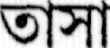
তাসা
